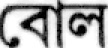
বোল
